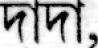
দাদা,
